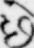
છે
